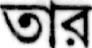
তার
